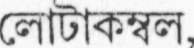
লোটাকম্বল,
